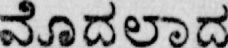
ಮೊದಲಾದ
